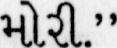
મોરી."
